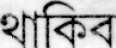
থাকিব
